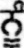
ਨੂੰ
